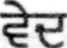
ਵੇਦ
